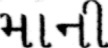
માની
